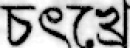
চৎখ্রে
